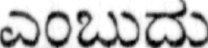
ಎಂಬುದು
